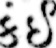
કંઈ
